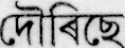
দৌৰিছে
